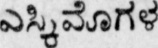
ಎಸ್ಕಿಮೊಗಳ
